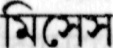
মিসেস
